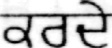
ਕਰਦੇ
